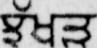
ਝੱਖੜ
